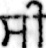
ਸੀ
